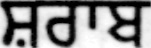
ਸ਼ਰਾਬ
